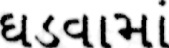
ઘડવામાં
